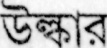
উল্কার
